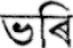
ভৰি
